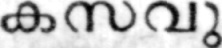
കസവു
